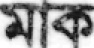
মাক
